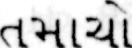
તમાચો
